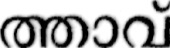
ത്താവ്
